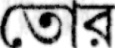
তোর
